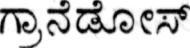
ಗ್ರಾನೆಡೋಸ್
